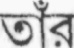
তাঁর
